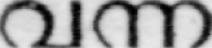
വന്ന
